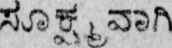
ಸೂಕ್ಷ್ಮವಾಗಿ
